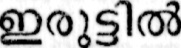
ഇരുട്ടില്‍
